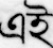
এই
